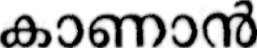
കാണാന്‍
